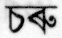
চক
